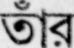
তাঁর
